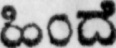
ಹಿಂದೆ
